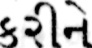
કરીને
